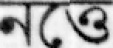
নত্তে
